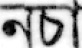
নচা
